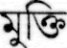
মুক্তি
